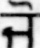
ਜੋ
